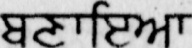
ਬਣਾਇਆ
